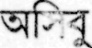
অসিবু
